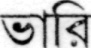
ভারি
